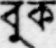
বুক
